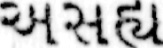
અસહ્ય
